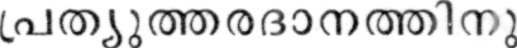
പ്രത്യുത്തരദാനത്തിനു
